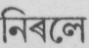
নিৰলে
